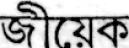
জীয়েক
